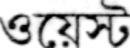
ওয়েস্ট
